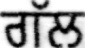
ਗੱਲ
